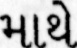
માથે
